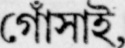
গোঁসাই,
